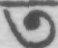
ত
